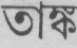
তাঙ্ক
